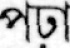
পঢ়া
